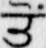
ਤੋਂ
